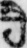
ਹੈ
